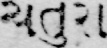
ચતુરા
